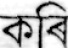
কৰি
